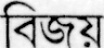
বিজয়
